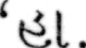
'હા.
